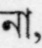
না,
